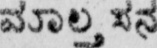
ಮಾಲ್ತಸನ
